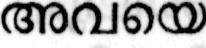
അവയെ
